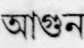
আগুন
